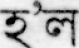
হ'ল
